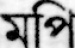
মপি
